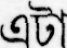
এটা
